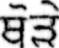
ਥੋੜੇ
